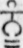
ਨੂੰ
